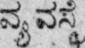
ವ್ಯವಸ್ಥೆ
